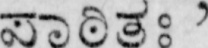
ಪಾಠಿತಃ
